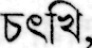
চৎখি,
